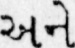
અને
